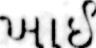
ખાઈ
